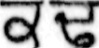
ਕਢ
